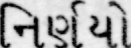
નિર્ણયો
